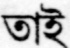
তাই
